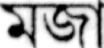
মজা
